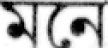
মনে
